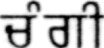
ਚੰਗੀ
